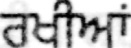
ਰਖੀਆਂ
